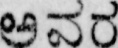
ಅವರ
